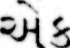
એક
